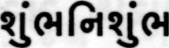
શુંભનિશુંભ
